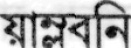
য়াম্লবনি
